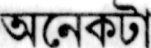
অনেকটা
